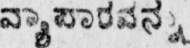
ವ್ಯಾಪಾರವನ್ನು
